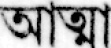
আত্মা
